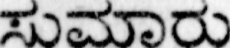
ಸುಮಾರು
